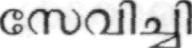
സേവിച്ചി
